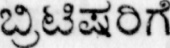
ಬ್ರಿಟಿಷರಿಗೆ
